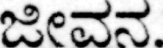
ಜೀವನ.
